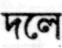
দলে
